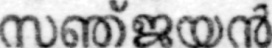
സഞ്ജയന്‍
